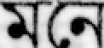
মনে
